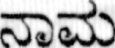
ನಾಮ
